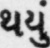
થયું
